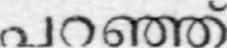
പറഞ്ഞ്
